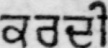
ਕਰਦੀ
